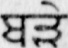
ਬੜੇ
